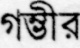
গম্ভীর
